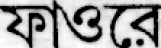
ফাওরে
